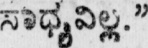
ಸಾಧ್ಯವಿಲ್ಲ.”
